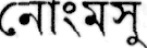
নোংমসু
